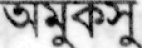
অমুকসু
